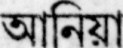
আনিয়া
